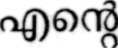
എന്റെ
